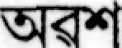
অৱশ
